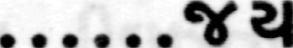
......જય
